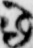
છે
